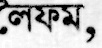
লৈফম,
